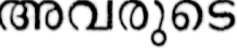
അവരുടെ
